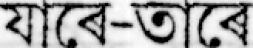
যাৰে-তাৰে
